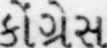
કોંગ્રેસ
